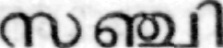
സഞ്ചി
